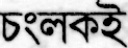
চংলকই
